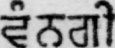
ਵੰਨਗੀ
